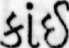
કાંઈ
